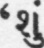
'શું
